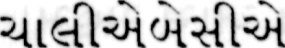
ચાલીએબેસીએ
